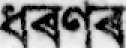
ধৰণৰ
